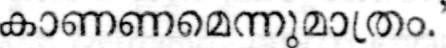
കാണണമെന്നുമാത്രം.’
